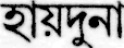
হায়দুনা
